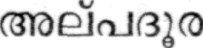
അല്പദൂര
